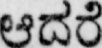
ಆದರೆ
